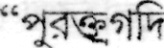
“পুরক্ত্রগদি
